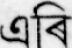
এৰি
